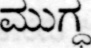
ಮುಗ್ಧ
